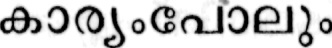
കാര്യംപോലും
